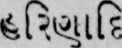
હરિણઆદિ
